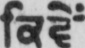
ਕਿਵੇਂ
